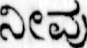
ನೀವು
